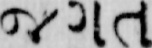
જગત
